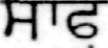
ਸਾਫ਼
